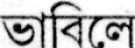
ভাবিলে
